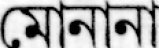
মোনানা
